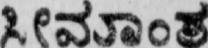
ಸೀಮಾಂತ
